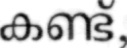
കണ്ട്,
